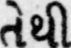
તેથી
